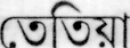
তেতিয়া
